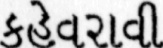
કહેવરાવી
